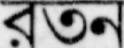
রতন
